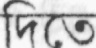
দিতে
